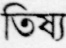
তিষ্য
